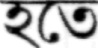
হতে
